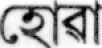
হোৱা
